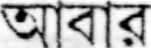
আবার
